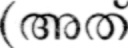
(അത്
